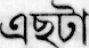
এছটা
